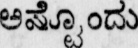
ಅಷ್ಟೊಂದು
